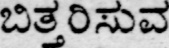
ಬಿತ್ತರಿಸುವ
